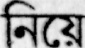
নিয়ে
